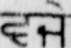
ਵਜੇ
